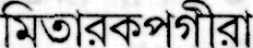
মিতারকপগীরা
